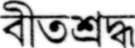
বীতশ্রদ্ধ
